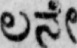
ಲನೇ
